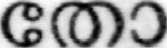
തോ
